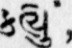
કહ્યું,
